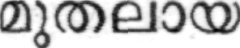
മുതലായ
